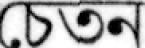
চেতন
